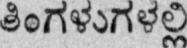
ತಿಂಗಳುಗಳಲ್ಲಿ
